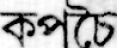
কপচৈ
